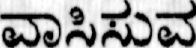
ವಾಸಿಸುವ
